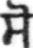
ਸੋ
